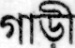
গাড়ী
